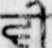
ਵੀ
